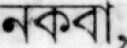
নকবা,
